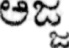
ಅಜ್ಜ
